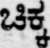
ಚಿಕ್ಕ
